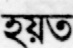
হয়ত
